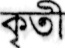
কৃতী
